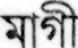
মাগী
